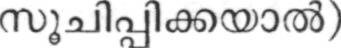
സൂചിപ്പിക്കയാല്‍)
